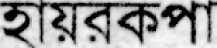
হায়রকপা
